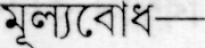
মূল্যবোধ-
